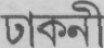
ঢাকনী
